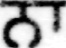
ਨਾ
